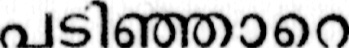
പടിഞ്ഞാറെ
